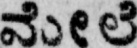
ಮೇಲೆ
